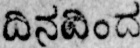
ದಿನದಿಂದ
